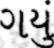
ગયું
